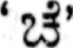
'ಚೆ'
